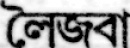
লৈজবা
